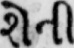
શેની
